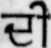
ਦੀ
